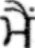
ਮੈਂ
